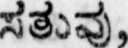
ಸತುವು,
